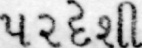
પરદેશી
